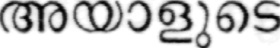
അയാളുടെ
